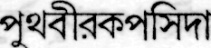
পুথবীরকপসিনা
